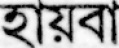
হায়বা
